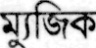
ম্যুজিক
